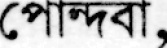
পোন্দবা,
